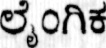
ಲೈಂಗಿಕ
